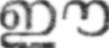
ഈ
